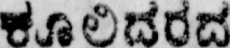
ಕೂಲಿದರದ
